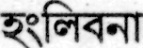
হংলিবনা
